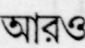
আরও
